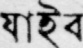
যাইব
